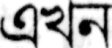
এখন
